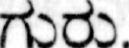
ಗುರು.
